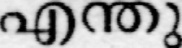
എന്തു
